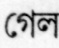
গেল
